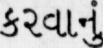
કરવાનું
